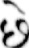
છે
